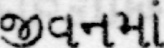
જીવનમાં
